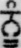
ਨੂੰ
